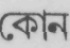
কোন
